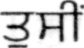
ਤੁਸੀਂ
